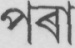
পৰা
